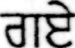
ਗਏ
